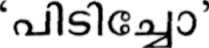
‘പിടിച്ചോ’
